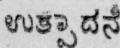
ಉತ್ಪಾದನೆ
